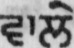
ਵਾਲੇ
